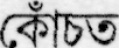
কোঁচত
